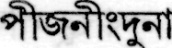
পীজনীংদুনা
